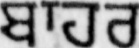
ਬਾਹਰ
